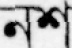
নশ
